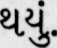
થયું.
